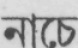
নাচে
